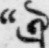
‘‘ঐ
